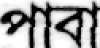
পাবা
